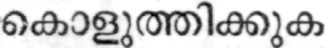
കൊളുത്തിക്കുക
